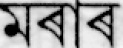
মৰাৰ
